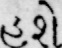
હશે
